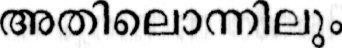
അതിലൊന്നിലും
